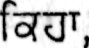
ਕਿਹਾ,
